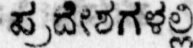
ಪ್ರದೇಶಗಳಲ್ಲಿ
